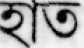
হাত
